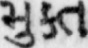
મુક્ત
